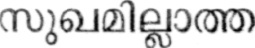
സുഖമില്ലാത്ത
